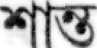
শান্ত
